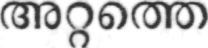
അറ്റത്തെ
